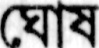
ঘোষ
